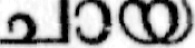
ചായ
